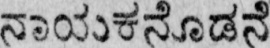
ನಾಯಕನೊಡನೆ
